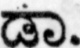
ಡಾ.
